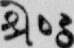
શ્રેષ્ઠ
